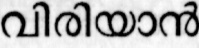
വിരിയാന്‍
